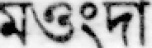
মওংদা
